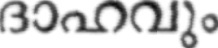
ദാഹവും
